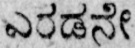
ಎರಡನೇ
